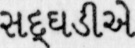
સદ્ઘડીએ
